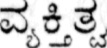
ವ್ಯಕ್ತಿತ್ವ
